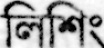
লিশিং
